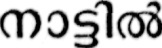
നാട്ടില്‍
